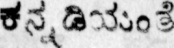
ಕನ್ನಡಿಯಂತೆ
